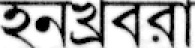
হনখ্রবরা
